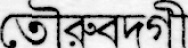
তৌরুবদগী
